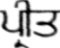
ਪ੍ਰੀਤ
